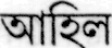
আহিল
